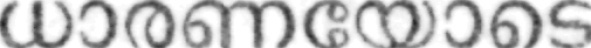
ധാരണയോടെ
